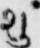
શું
